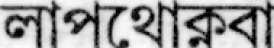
লাপথোক্নবা
